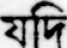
যদি
